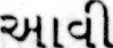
આવી
